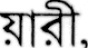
য়ারী,
